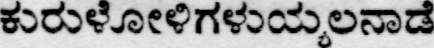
ಕುರುಳೋಳಿಗಳುಯ್ಯಲನಾಡೆ
